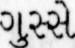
ગુસ્સે
